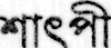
শাৎপী
